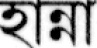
হান্না
